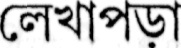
লেখাপড়া
